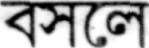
বসলে
